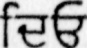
ਦਿਓ
